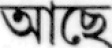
আছে
